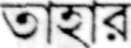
তাহার
